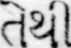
તેથી
